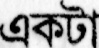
একটা
